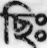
ছিঃ
